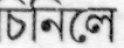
চিনিলে
